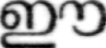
ഈ
